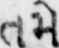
તમે
